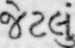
જેટલું
